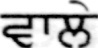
ਵਾਲੇ
